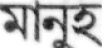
মানুহ
